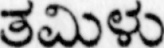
ತಮಿಳು
